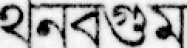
থনবগুম
